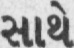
સાથે
